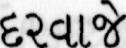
દરવાજે
